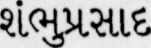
શંભુપ્રસાદ
